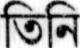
তিনি
